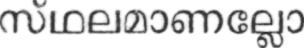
സ്ഥലമാണല്ലോ
